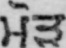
ਮੋੜ
